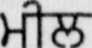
ਮੀਲ
